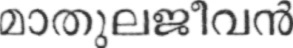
മാതുലജീവന്‍
